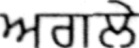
ਅਗਲੇ
